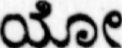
ಯೋ
